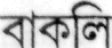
বাকলি
